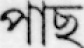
পাছ
